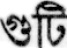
গুটি
